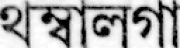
থম্বালগা
